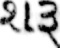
શરૂ
